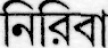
নিরিবা
